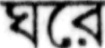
ঘরে
